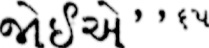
જોઈએ"૬૫
